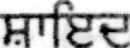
ਸ਼ਾਇਦ
